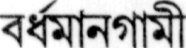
বর্ধমানগামী
